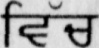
ਵਿੱਚ
